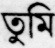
তুমি
